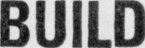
BUILD
